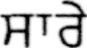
ਸਾਰੇ
